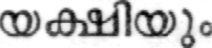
യക്ഷിയും
